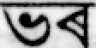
ভৰ
